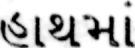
હાથમાં
